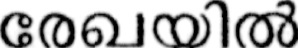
രേഖയില്‍
